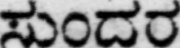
ಸುಂದರ
